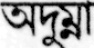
অদুম্না
